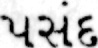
પસંદ
